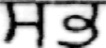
ਸਭ
